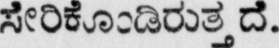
ಸೇರಿಕೊಂಡಿರುತ್ತದೆ.
